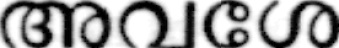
അവശേ
